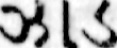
ઝાડ
